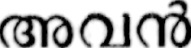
അവന്‍
